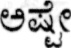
ಅಷ್ಟೇ
